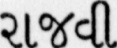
રાજવી
